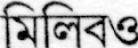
মিলিবও
